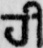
ਹੀ
